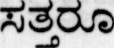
ಸತ್ತರೂ
